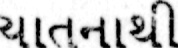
યાતનાથી
